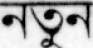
নতুন
